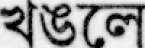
খঙলে
